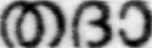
തദാ
